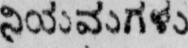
ನಿಯಮಗಳು
